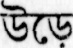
উড়ে
